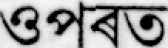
ওপৰত
